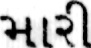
મારી
